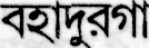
বহাদুরগা
